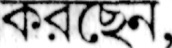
করছেন,
